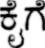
ಕೈಗೆ
